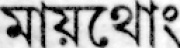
মায়থোং
